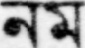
নম
